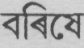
বৰিষে
